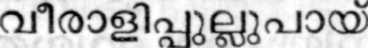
വീരാളിപ്പുല്ലുപായ്
